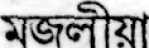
মজলীয়া
